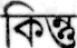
কিন্তু
